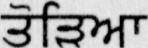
ਤੋੜਿਆ
